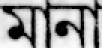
মানা
